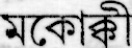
মকোক্কী
